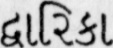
દ્વારિકા
